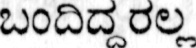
ಬಂದಿದ್ದರಲ್ಲ
